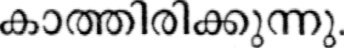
കാത്തിരിക്കുന്നു.
